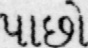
પાછો
